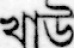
খাউ
